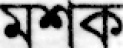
মশক
